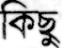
কিছু
